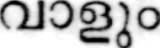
വാളും
